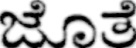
ಜೊತೆ
